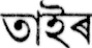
তাইৰ
